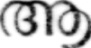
ആ
